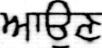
ਆਉਣ
